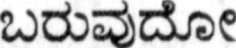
ಬರುವುದೋ
